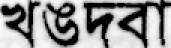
খঙদবা
